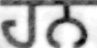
ਹਨ
